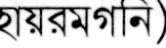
হায়রমগনি
